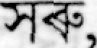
সৰু,
